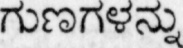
ಗುಣಗಳನ್ನು
